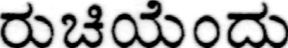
ರುಚಿಯೆಂದು
